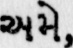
અમે,
